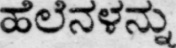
ಹೆಲೆನಳನ್ನು
